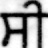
ਸੀ
